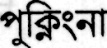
পুক্নিংনা
